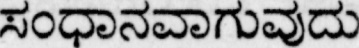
ಸಂಧಾನವಾಗುವುದು
